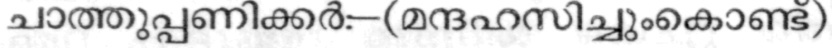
ചാത്തുപ്പണിക്കര്‍:-(മന്ദഹസിച്ചുംകൊണ്ട്)
